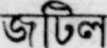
জটিল
